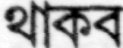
থাকব
